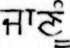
ਜਾਣੂੰ
